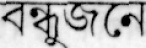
বন্ধুজনে
